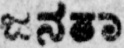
ಜನತಾ
